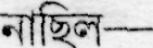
নাছিল-
